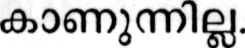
കാണുന്നില്ല.
